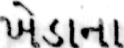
ખેડાના
